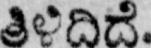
ತಿಳಿದಿದೆ.
